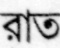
রাত
